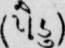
(પૈડુ)
